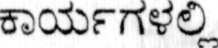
ಕಾರ್ಯಗಳಲ್ಲಿ
